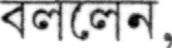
বললেন,
